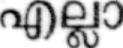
എല്ലാ
